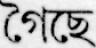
গৈছে
